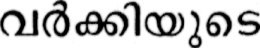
വര്‍ക്കിയുടെ
